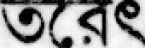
তরেৎ
